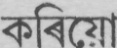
কৰিয়ো
